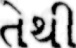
તેથી
